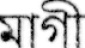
মাগী
